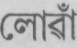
লোৱাঁ
